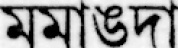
মমাঙদা
